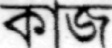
কাজ
